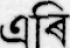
এৰি
